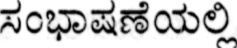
ಸಂಭಾಷಣೆಯಲ್ಲಿ
